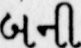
બની
